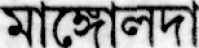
মাঙ্গোলদা
